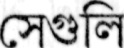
সেগুলি
